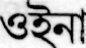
ওইনা
